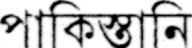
পাকিস্তানি
